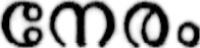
നേരം
